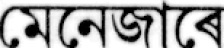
মেনেজাৰে
